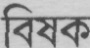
বিষক
